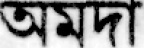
অমদা
